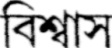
বিশ্বাস
